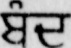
ਬੰਦ
